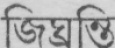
জিঘ্ৰন্তি
